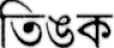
তিঙক
